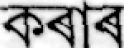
কৰাৰ
